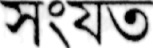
সংযত
